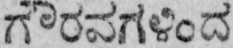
ಗೌರವಗಳಿಂದ
